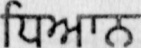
ਧਿਆਨ
